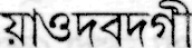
য়াওদবদগী
